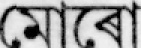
মোৰো
